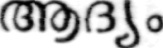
ആദ്യം
